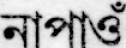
নাপাওঁ
